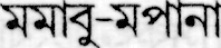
মমাবু-মপানা
